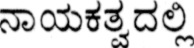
ನಾಯಕತ್ವದಲ್ಲಿ
